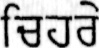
ਚਿਹਰੇ
